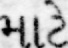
માટે
